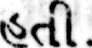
હતી.
